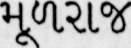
મૂળરાજ
